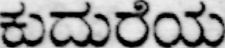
ಕುದುರೆಯ
